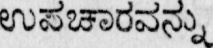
ಉಪಚಾರವನ್ನು
